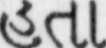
હતા
